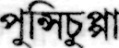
পুন্সিচুপ্পা
